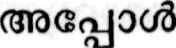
അപ്പോള്‍
